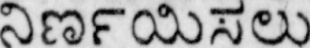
ನಿರ್ಣಯಿಸಲು
